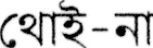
থোই-না
